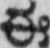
ಈ
